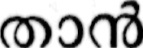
താന്‍
